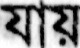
যায়
